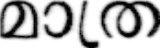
മാത്ര
